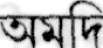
অমদি
